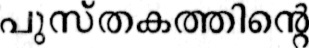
പുസ്തകത്തിന്റെ
